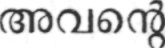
അവന്റെ
